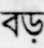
বড়
